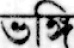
ভঙ্গি
